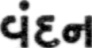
વંદન
